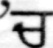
'ਚ
